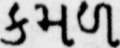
કમળ
